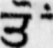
ਤੋਂ
